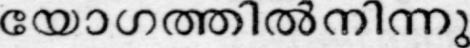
യോഗത്തില്‍നിന്നു
